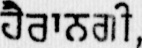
ਹੈਰਾਨਗੀ,
